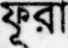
ফূরা
